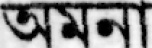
অমনা
